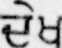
ਦੇਖ
